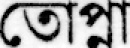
তোপ্না
